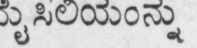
ಮೈಸಿಲಿಯಂನ್ನು
